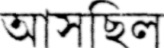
আসছিল
